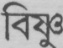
বিষ্ণু
